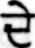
ਦੇ
